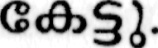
കേട്ടു.
